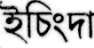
ইচিংদা
